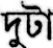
দুটা
